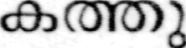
കത്തു
